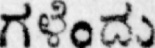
ಗಳೆಂದು
